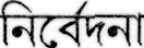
নির্বেদনা
